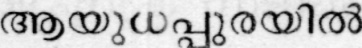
ആയുധപ്പുരയില്‍
